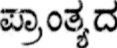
ಪ್ರಾಂತ್ಯದ
